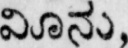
ಮೀನು,
